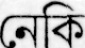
নেকি
